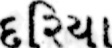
દરિયા
